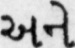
અને
